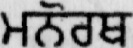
ਮਨੋਰਥ
